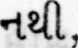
નથી,
